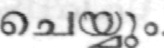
ചെയ്യും.
